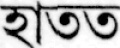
হাতত
